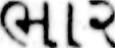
ભાર
